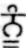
ਨੂੰ
